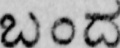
ಬಂದ
